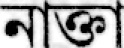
নাক্তা
